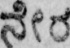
ನೇರ
